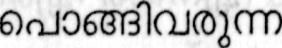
പൊങ്ങിവരുന്ന
